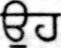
ਉਹ
